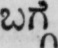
ಬಗ್ಗೆ
